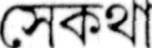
সেকথা
